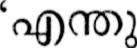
‘എന്തു
